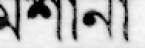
মশানা
